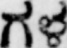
ಗಳ
